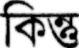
কিন্তু
